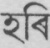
হৰি
